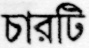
চারটি
